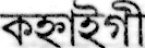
কহ্নাইগী
